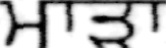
ਮਾੜਾ
